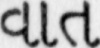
વાત
